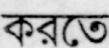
করতে
